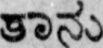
ತಾನು
